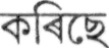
কৰিছে
